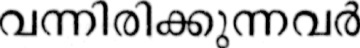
വന്നിരിക്കുന്നവര്‍
